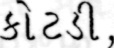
કોટડી,
